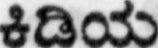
ಕಿಡಿಯ
